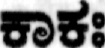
ಕಾಕಃ
